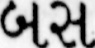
બસ
